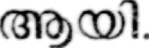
ആയി.
